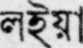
লইয়া
